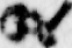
જ
